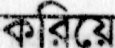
করিয়ে
